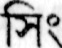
সিং
